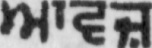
ਆਵਜ਼
